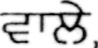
ਵਾਲੇ,
